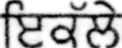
ਇਕੱਲੇ
